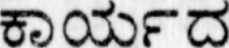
ಕಾರ್ಯದ
